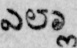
ಎಲ್ಲಾ
